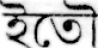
ইতৌ
